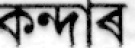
কন্দাৰ
